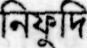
নিফুদি
